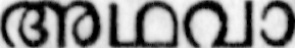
അഥവാ
